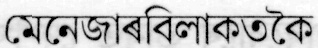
মেনেজাৰবিলাকতকৈ
